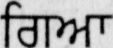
ਗਿਆ
